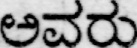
ಅವರು
